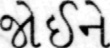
જોઈને
